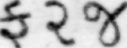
ફરજ
